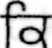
ਕਿ
